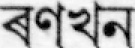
ৰণখন
